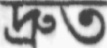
দ্রুত
